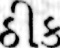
ઠીક
